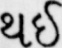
થઈ
